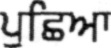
ਪੁਛਿਆ
